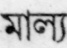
মাল্য
